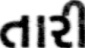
તારી
